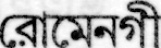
রোমেনগী
